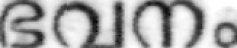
ഭവനം
